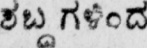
ಶಬ್ದಗಳಿಂದ
